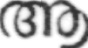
ആ
